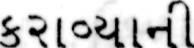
કરાવ્યાની
